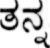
ತನ್ನ
